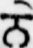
ਨੇ
